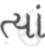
ત્યાં
